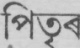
পিতৃৰ
